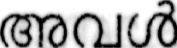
അവള്‍
